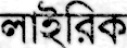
লাইরিক
